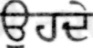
ਉਹਦੇ
